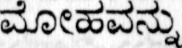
ಮೋಹವನ್ನು
